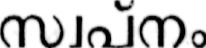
സ്വപ്നം
